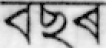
বছৰ
